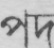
পদ
